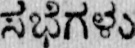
ಸಭೆಗಳು
